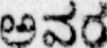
ಅವರ
